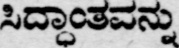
ಸಿದ್ಧಾಂತವನ್ನು
